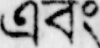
এবং
